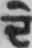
ਦੇ
